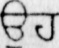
ਉਹ
